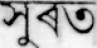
সুৰত
